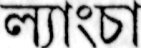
ল্যাংচা
